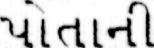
પોતાની
